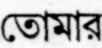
তোমার
